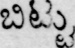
ಬಿಟ್ಟು
